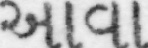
આવા
